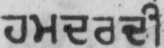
ਹਮਦਰਦੀ
